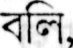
বলি,
